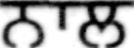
ਨਾਲ
